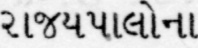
રાજ્યપાલોના
